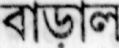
বাড়াল
